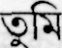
তুমি
